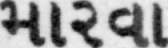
મારવા
